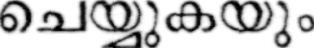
ചെയ്യുകയും
